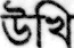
উখি
